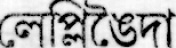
লেপ্লিঙৈদা
